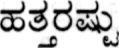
ಹತ್ತರಷ್ಟು
